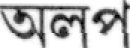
অলপ
